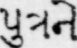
પુત્રને
